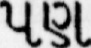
પણ
